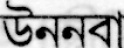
উননবা
